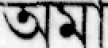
অমা
